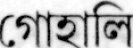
গোহালি
